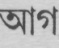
আগ
